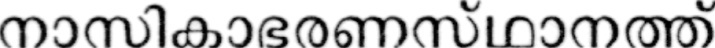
നാസികാഭരണസ്ഥാനത്ത്
